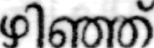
ഴിഞ്ഞ്
